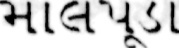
માલપૂડા
